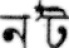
ন'ট
